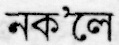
নক'লে
